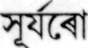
সূর্যৰো
